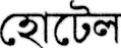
হোটেল
